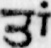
ਤਾਂ
